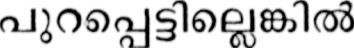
പുറപ്പെട്ടില്ലെങ്കില്‍
